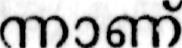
ന്നാണ്
